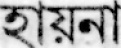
হায়না
